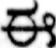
ಈ
